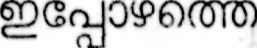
ഇപ്പോഴത്തെ
